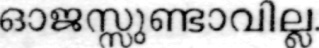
ഓജസ്സുണ്ടാവില്ല.
